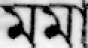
মমা
